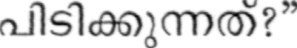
പിടിക്കുന്നത്?”
